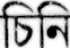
চিনি
